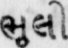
ભૂલી
